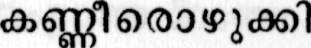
കണ്ണീരൊഴുക്കി
